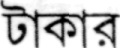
টাকার
